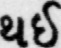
થઈ
